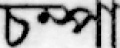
চম্পা
